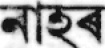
নাহৰ
